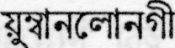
য়ুম্বানলোনগী
